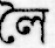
লৈ
